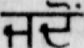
ਜਦੋਂ
